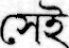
সেই
